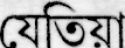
যেতিয়া
